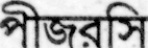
পীজরসি
